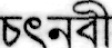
চৎনবী
